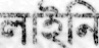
লাইনি
